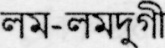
লম-লমদুগী
